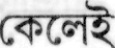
কেলেই
